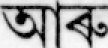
আৰু
